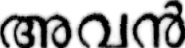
അവന്‍
